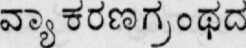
ವ್ಯಾಕರಣಗ್ರಂಥದ
